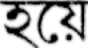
হয়ে
